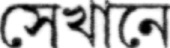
সেখানে
